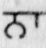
ਨਾ
